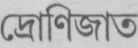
দ্ৰোণিজাত
